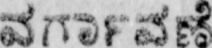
ವರ್ಗಾವಣೆ
